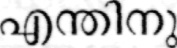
എന്തിനു
